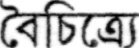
বৈচিত্র্যে
